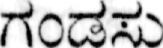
ಗಂಡಸು
